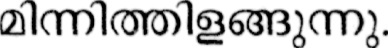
മിന്നിത്തിളങ്ങുന്നു.
